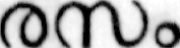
രസം
